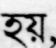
হয়,
